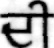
ਦੀ
